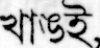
খাঙই,
